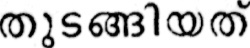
തുടങ്ങിയത്
